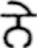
ਨੇ
